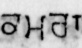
ਕਮਰਾ
